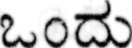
ಒಂದು
